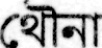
থৌনা
